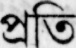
প্রতি
